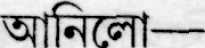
আনিলো-
